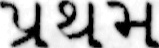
પ્રથમ
